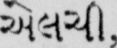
એલચી,
